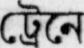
ট্রেনে
